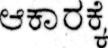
ಆಕಾರಕ್ಕೆ
